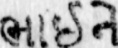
ભાઈને
